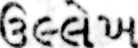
ઉલ્લેખ
